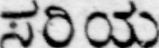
ಸರಿಯ
